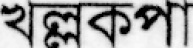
খল্লকপা
